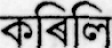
কৰিলি
